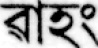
ৱাহং
